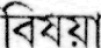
বিষয়া
